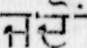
ਜਦੋਂ
